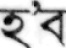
হ'ব
